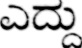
ಎದ್ದು
